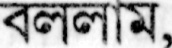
বললাম,
